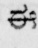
ಈ
